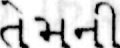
તેમની
